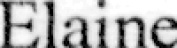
Elaine
